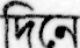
দিনে
